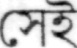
সেই
